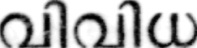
വിവിധ
